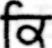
ਕਿ
